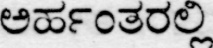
ಅರ್ಹಂತರದಲ್ಲಿ
